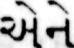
એને
